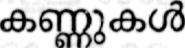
കണ്ണുകള്‍
